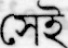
সেই
